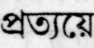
প্রত্যয়ে
